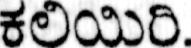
ಕಲಿಯಿರಿ.
